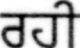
ਰਹੀ
